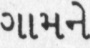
ગામને
